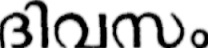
ദിവസം
